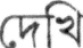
দেখি
